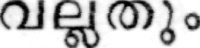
വല്ലതും
